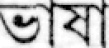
ভাষা
